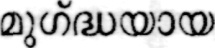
മുഗ്ദ്ധയായ
